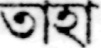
তাহা
